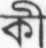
কী
